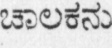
ಚಾಲಕನು
